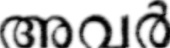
അവര്‍
